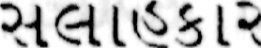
સલાહકાર
